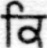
ਕਿ
